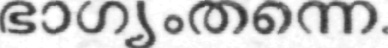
ഭാഗ്യംതന്നെ.
